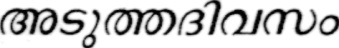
അടുത്തദിവസം
